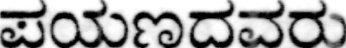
ಪಯಣದವರು
